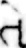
તે
